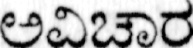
ಅವಿಚಾರ
